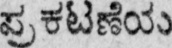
ಪ್ರಕಟಣೆಯ
